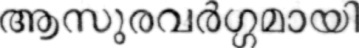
ആസുരവര്‍ഗ്ഗമായി
